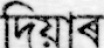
দিয়াৰ
